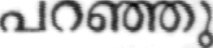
പറഞ്ഞു
